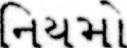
નિયમો
